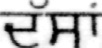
ਦੱਸਾਂ
